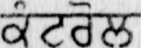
ਕੰਟਰੋਲ
